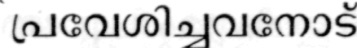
പ്രവേശിച്ചവനോട്
